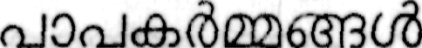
പാപകര്‍മ്മങ്ങള്‍
